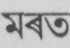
মৰত
